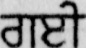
ਗਈ
